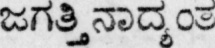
ಜಗತ್ತಿನಾದ್ಯಂತ
